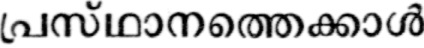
പ്രസ്ഥാനത്തെക്കാള്‍
